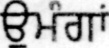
ਉਮੰਗਾਂ
